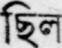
ছিল
